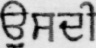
ਉਸਦੀ
